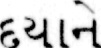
દયાને
